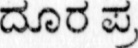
ದೂರಪ್ರ
